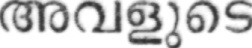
അവളുടെ
